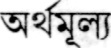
অর্থমূল্য
